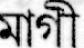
মাগী
